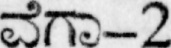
ವೆಗಾ-2
